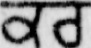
ਕਰ
